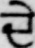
ਦੇ
